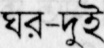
ঘর-দুই
